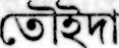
তৌইদা
